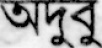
অদুবু
